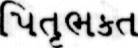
પિતૃભક્ત
